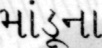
માંડૂના
